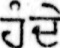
ਹੁੰਦੇ
